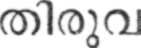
തിരുവ
